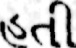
હતી
